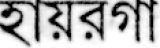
হায়রগা
